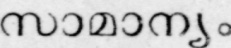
സാമാന്യം
